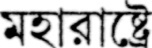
মহারাষ্ট্রে
